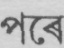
পৰে
